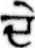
ਦੇ
